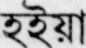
হইয়া
